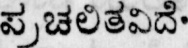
ಪ್ರಚಲಿತವಿದೆ.
